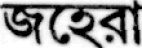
জহেরা
